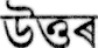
উত্তৰ
